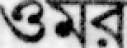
ওমর
